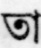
তা
